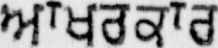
ਆਖਰਕਾਰ
